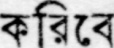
করিবে
